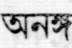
অনঙ্গ
